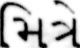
મિત્રે
